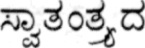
ಸ್ವಾತಂತ್ರ್ಯದ
